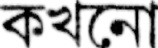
কখনো
